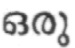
ഒരു
